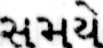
સમયે
